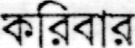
করিবার
